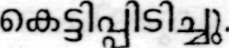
കെട്ടിപ്പിടിച്ചു.
